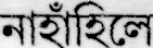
নাহাঁহিলে
